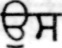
ਉਸ
